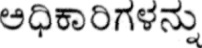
ಅಧಿಕಾರಿಗಳನ್ನು
